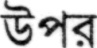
উপর
